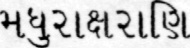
મધુરાક્ષરાણિ
